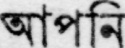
আপনি
